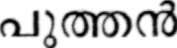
പുത്തന്‍
